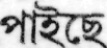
পাইছে
